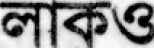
লাকও
